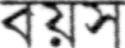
বয়স
